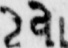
ટેવો
